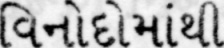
વિનોદોમાંથી
